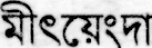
মীৎয়েংদা
